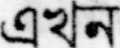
এখন
